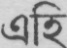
এহি
